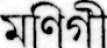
মণিগী
